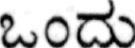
ಒಂದು
